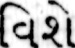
વિશે
